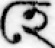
হে
